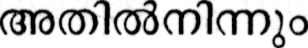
അതില്‍നിന്നും
